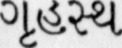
ગૃહસ્થ
